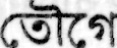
তৌগে
